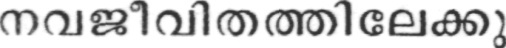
നവജീവിതത്തിലേക്കു
